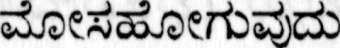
ಮೋಸಹೋಗುವುದು
